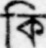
কি
